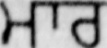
ਮਾਰ
